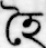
হৈ
